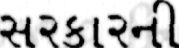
સરકારની
